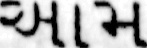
આમ
